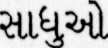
સાધુઓ
